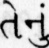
તેનું
